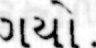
ગયો.
